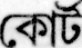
কোর্ট
